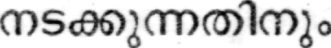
നടക്കുന്നതിനും
